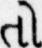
તો
